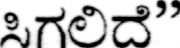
ಸಿಗಲಿದೆ"
